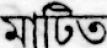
মাটিত
